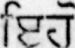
ਇਕੋ
